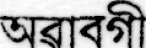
অৱাবগী
